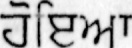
ਹੋਇਆ
